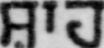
ਸ਼ਾਹ
